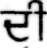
ਦੀ
